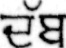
ਦੱਬ
